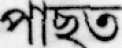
পাছত
